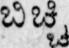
ಬಿಚ್ಚಿ
